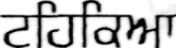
ਟਹਿਕਿਆ
